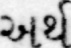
અર્થ
